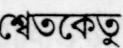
শ্বেতকেতু
